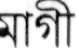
মাগী
